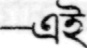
-এই
